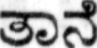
ತಾನೆ
